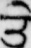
ਤੇ
